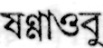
ষণ্ণাওবু
